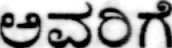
ಅವರಿಗೆ
